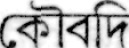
কৌবদি
